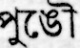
পুঙৌ
